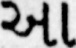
આ
